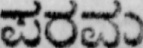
ಪರಮ
